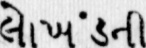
લોખંડની
